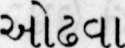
ઓઢવા
